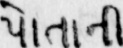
પોતાની
